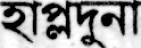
হাপ্লদুনা
